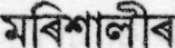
মৰিশালীৰ
